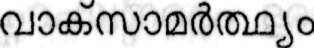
വാക്സാമര്‍ത്ഥ്യം
